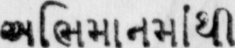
અભિમાનમાંથી
